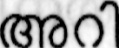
അറി
